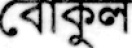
বোকুল
